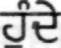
ਹੁੰਦੇ
